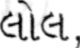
લોલ,
